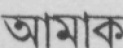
আমাক
